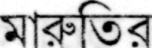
মারুতির
